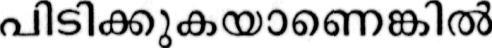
പിടിക്കുകയാണെങ്കില്‍
